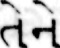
તેને
